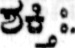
ಶಕ್ತಿಃ
